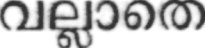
വല്ലാതെ
